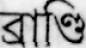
ব্রাণ্ডি
